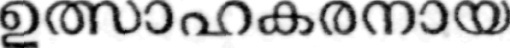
ഉത്സാഹകരനായ
